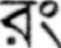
রং
